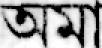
অমা
